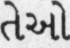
તેઓ
